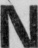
N
